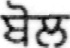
ਬੋਲ
